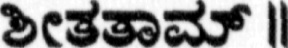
ಶೀತತಾಮ್||
